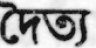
দৈত্য
